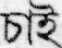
চাই
